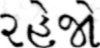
રહેજો
